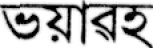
ভয়াৱহ
